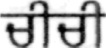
ਚੀਚੀ
